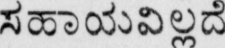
ಸಹಾಯವಿಲ್ಲದೆ
